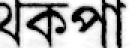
থকপা
